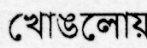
খোঙলোয়
